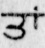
ਤਾਂ
